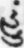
હું
